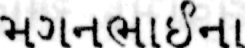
મગનભાઈના
